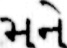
મને
